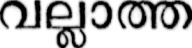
വല്ലാത്ത
